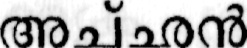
അച്ഛന്‍
